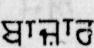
ਬਾਜ਼ਾਰ
